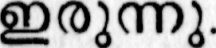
ഇരുന്നു.
